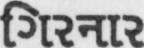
ગિરનાર
